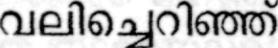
വലിച്ചെറിഞ്ഞ്
